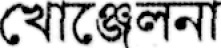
খোঞ্জেলনা
